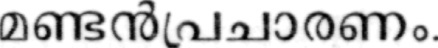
മണ്ടന്‍പ്രചാരണം.
